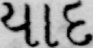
યાદ
